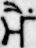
ਮੈਂ
